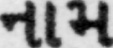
નામ
